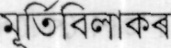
মূর্তিবিলাকৰ
